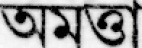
অমত্তা
